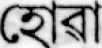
হোৱা
